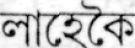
লাহেকৈ
